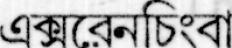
এক্সেরেনচিংবা
